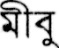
মীবু
